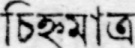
চিহ্নমাত্র
